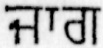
ਜਾਗ
